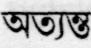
অত্যন্ত
